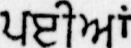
ਪਈਆਂ
